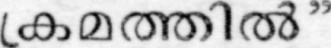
ക്രമത്തില്‍”
